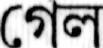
গেল
